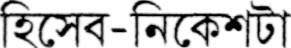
হিসেব-নিকেশটা
